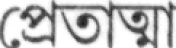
প্রেতাত্মা
